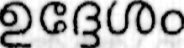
ഉദ്ദേശം
